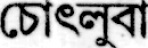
চোৎলুবা
